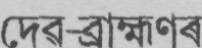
দেৱ-ব্ৰাহ্মণৰ
